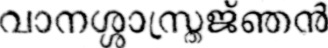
വാനശ്ശാസ്ത്രജ്ഞന്‍
